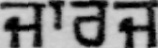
ਜਾਰਜ
